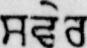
ਸਵੇਰ
